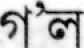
গ'ল
